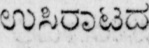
ಉಸಿರಾಟದ
